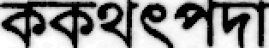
ককথৎপদা
